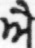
ਐ
